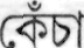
কেঁচা
